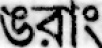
ঙরাং
